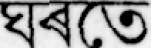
ঘৰতে
